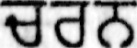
ਚਰਨ
